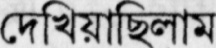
দেখিয়াছিলাম
